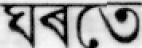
ঘৰতে
